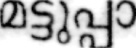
മട്ടുപ്പാ
